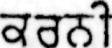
ਕਰਨੀ
